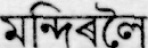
মন্দিৰলৈ
